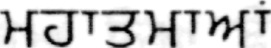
ਮਹਾਤਮਾਆਂ
